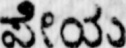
ಪೇಯ
